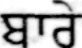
ਬਾਰੇ
